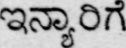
ಇನ್ಯಾರಿಗೆ
